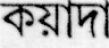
কয়াদা
